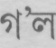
গ'ল
